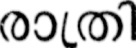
രാത്രി
